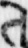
તે
